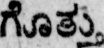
ಗೊತ್ತು
